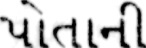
પોતાની
